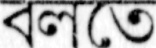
বলতে
